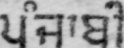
ਪੰਜਾਬੀ
